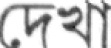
দেখা
